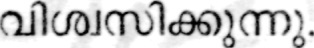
വിശ്വസിക്കുന്നു.
